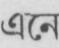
এনে
